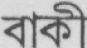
বাকী
